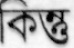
কিন্তু
